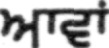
ਆਵਾਂ
